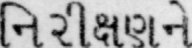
નિરીક્ષણને
